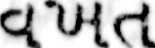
વખત
